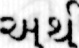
અર્થ
